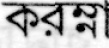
করম্না
